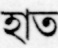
হাত
